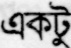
একটু
